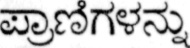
ಪ್ರಾಣಿಗಳನ್ನು
